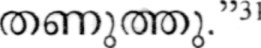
തണുത്തു."31
